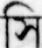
সি
